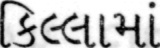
કિલ્લામાં
